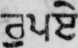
ਰੁਪਏ
